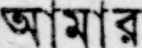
আমার
